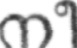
നീ
